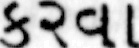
કરવા
